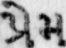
પ્રેમ
